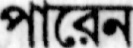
পারেন
